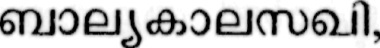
ബാല്യകാലസഖി,
